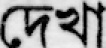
দেখা
